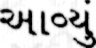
આવ્યું
